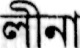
লীনা
